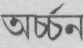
অৰ্চ্চন
